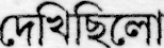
দেখিছিলো
